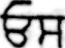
ਓਸ
